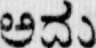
ಅದು
